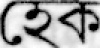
হেক
